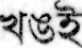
খঙই
